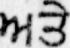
ਅਤੇ
